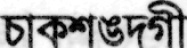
চাকশঙদগী
